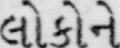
લોકોને
